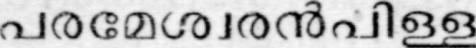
പരമേശ്വരന്‍പിള്ള
